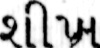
શીખ
